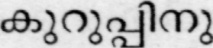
കുറുപ്പിനു
